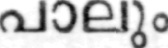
പാലും
